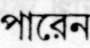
পারেন
